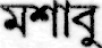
মশাবু
